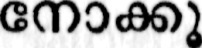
നോക്കൂ
